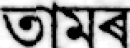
তামৰ
